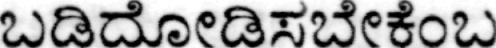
ಬಡಿದೋಡಿಸಬೇಕೆಂಬ
